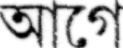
আগে
